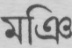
মঞি
